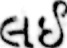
લઈ
